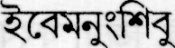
ইবেমনুংশিবু
